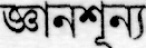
জ্ঞানশূন্য
